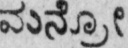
ಮನ್ರೋ
